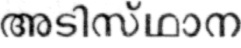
അടിസ്ഥാന
